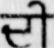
ਦੀ
